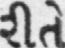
રીતે
